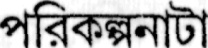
পরিকল্পনাটা
